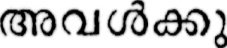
അവള്‍ക്കു
